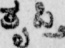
ತೃಪ್ತಿ
